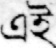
এই
